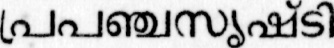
പ്രപഞ്ചസൃഷ്ടി
